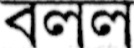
বলল
